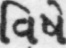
વિષે
